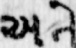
અને
